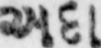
અદા
